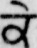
ਕੇ
